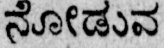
ನೋಡುವ
